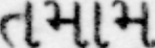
તમામ
